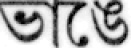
ভাঙে
